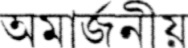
অমার্জনীয়
